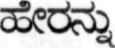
ಹೇರನ್ನು
